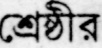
শ্রেষ্ঠীর
